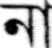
না
